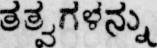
ತತ್ವಗಳನ್ನು
